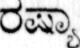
ರಷ್ಯಾ
